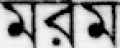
মরম
